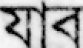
যাব
